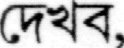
দেখব,
